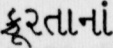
ક્રૂરતાનાં
